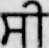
ਸੀ
